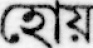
হোয়
